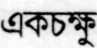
একচক্ষু
